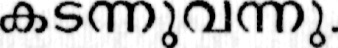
കടന്നുവന്നു.
